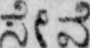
ಸೇವೆ
